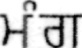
ਮੰਗ
